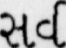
સર્વ
